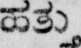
ಹತ್ತು
